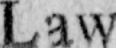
Law
